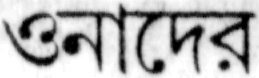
ওনাদের
